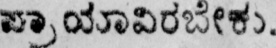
ಪ್ರಾಯಾವಿರಬೇಕು.
